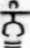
ਨੂੰ
